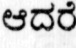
ಆದರೆ
